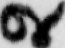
જ
